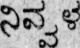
ನಿವ್ವಳ
